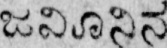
ಜಮೀನಿನ
